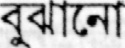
বুঝানো
